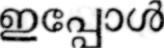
ഇപ്പോള്‍
